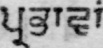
ਪ੍ਰਭਾਵਾਂ
